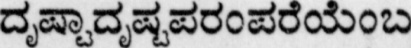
ದೃಷ್ಟಾದೃಷ್ಟಪರಂಪರೆಯೆಂಬ
